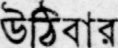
উঠিবার
